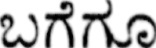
ಬಗೆಗೂ
